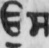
ਉਸ
